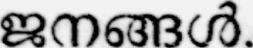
ജനങ്ങള്‍.
